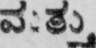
ಮತ್ತು
